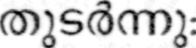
തുടര്‍ന്നു:
